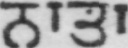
ਨਾਤਾ
